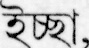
ইচ্ছা,
